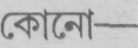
কোনো-
